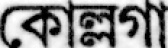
কোল্লগা
